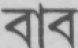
বাব
